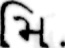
મિ.
